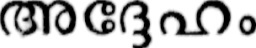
അദ്ദേഹം
